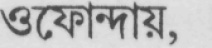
ওফোন্দায়,
